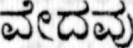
ವೇದವು
